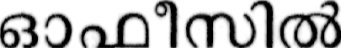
ഓഫീസില്‍
